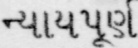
ન્યાયપૂર્ણ
